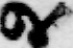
જ
